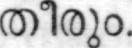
തീരും.
